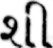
શી
